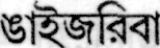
ঙাইজরিবা
